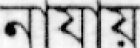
নাযায়
